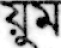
য়ুম
